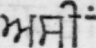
ਅਸੀਂ
